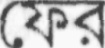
ফের
